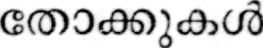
തോക്കുകള്‍
